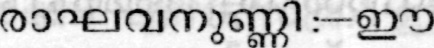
രാഘവനുണ്ണി:-ഈ
